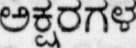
ಅಕ್ಷರಗಳ
